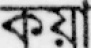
কয়া
